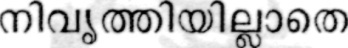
നിവൃത്തിയില്ലാതെ
